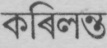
কৰিলন্ত
